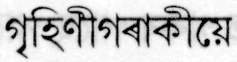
গৃহিণীগৰাকীয়ে
